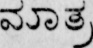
ಮಾತ್ರ
